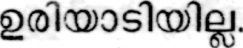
ഉരിയാടിയില്ല.
